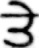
ਤੇ
